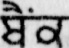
ਬੈਂਕ
